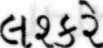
લશ્કરે
